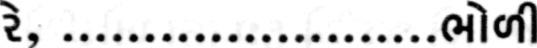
રે,............ભોળી
